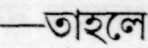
–তাহলে
